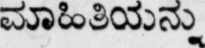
ಮಾಹಿತಿಯನ್ನು
